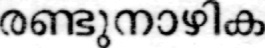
രണ്ടുനാഴിക
